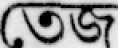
তেজ
